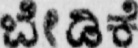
ಬೇಡಿಕೆ
